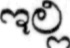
ಇಲ್ಲಿ
